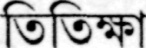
তিতিক্ষা
